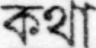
কথা
